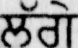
ਲੱਗੇ
